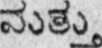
ಮತ್ತು
